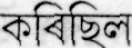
কৰিছিল
